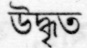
উদ্ধৃত
